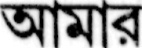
আমার
